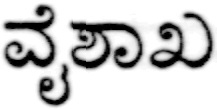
ವೈಶಾಖ
